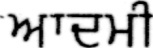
ਆਦਮੀ
